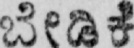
ಬೇಡಿಕೆ
